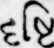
દષ્ટિ
